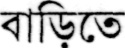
বাড়িতে
